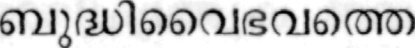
ബുദ്ധിവൈഭവത്തെ
